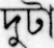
দুটা
